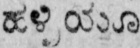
ಹಳ್ಳಿಯೂ
